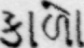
કાળો
